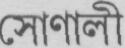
সোণালী
